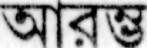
আরম্ভ
